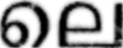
ലെ
